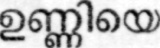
ഉണ്ണിയെ
